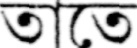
তাতে
